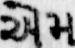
એમ
